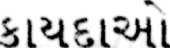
કાયદાઓ
